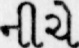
નીચે
